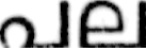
പല
